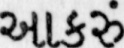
આકરું
